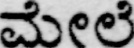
ಮೇಲೆ
